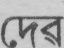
দেৱ
